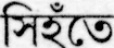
সিহঁতে
